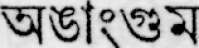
অঙাংগুম
